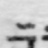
ਤੋਂ
